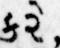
કરે,
